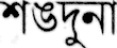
শঙদুনা
